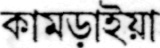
কামড়াইয়া
